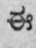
ಈ
